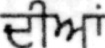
ਦੀਆਂ
